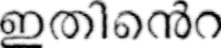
ഇതിന്റെ
